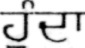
ਹੁੰਦਾ
